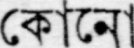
কোনো
